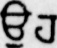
ਉਹ
